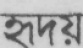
হৃদয়
